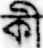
কী
